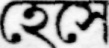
হেসে
